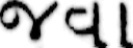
જવા
